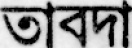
তাবদা
